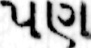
પણ
